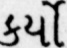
કર્યો
